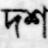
দশ
